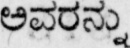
ಅವರನ್ನು
